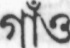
গাঁও
